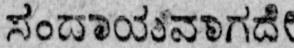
ಸಂದಾಯವಾಗದೇ
